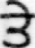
ਤੇ
